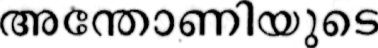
അന്തോണിയുടെ
